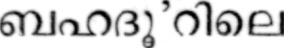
ബഹദൂ'റിലെ
